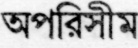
অপরিসীম
